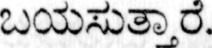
ಬಯಸುತ್ತಾರೆ.
